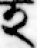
হ
